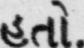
હતો.
